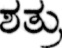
ಶತ್ರು
